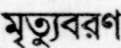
মৃত্যুবরণ
